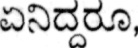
ಏನಿದ್ದರೂ,
